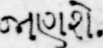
જાણશે.
